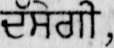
ਦੱਸੇਗੀ,
